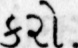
કરો.
